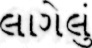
લાગેલું
